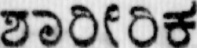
ಶಾರೀರಿಕ
